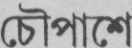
চৌপাশে
